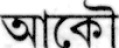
আকৌ
